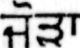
ਜੋੜਾ
